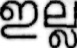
ഇല്ല
